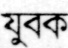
যুবক
